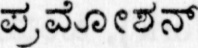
ಪ್ರಮೋಶನ್
